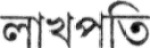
লাখপতি
